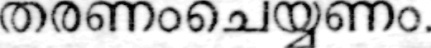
തരണംചെയ്യണം.
